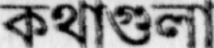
কথাগুলা
